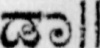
ಡಾ||
